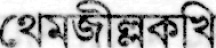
থেমজীল্লকখি
